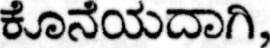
ಕೊನೆಯದಾಗಿ,
